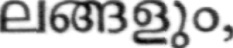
ലങ്ങളും,
